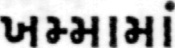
ખમ્માં
